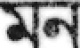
মন
